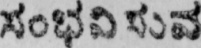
ಸಂಭವಿಸುವ
